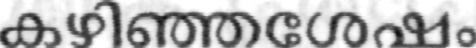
കഴിഞ്ഞശേഷം
